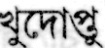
খুদোপ্তু
